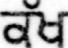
ਕੱਖ
